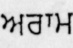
ਅਰਾਮ
